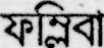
ফম্লিবা
